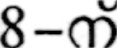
8-ന്
